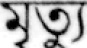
মৃত্যু
